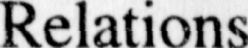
Relations
